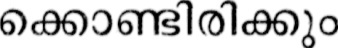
ക്കൊണ്ടിരിക്കും
